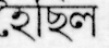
হৈছিল
